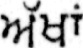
ਅੱਖਾਂ
